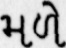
મળે
